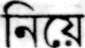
নিয়ে
